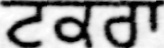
ਟਕਰਾ
